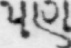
પણ
